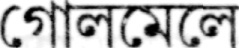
গোলমেলে
